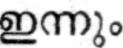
ഇന്നും
